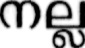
നല്ല
